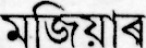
মজিয়াৰ
